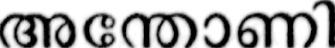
അന്തോണി
